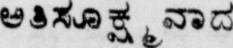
ಅತಿಸೂಕ್ಷ್ಮವಾದ
